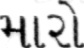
મારો
